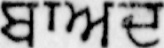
ਬਾਅਦ
